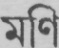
মণি
